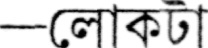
–লোকটা
